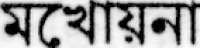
মখোয়না
